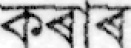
কৰাৰ
